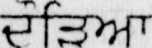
ਦੌੜਿਆ
